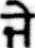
ਜੇ
